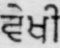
ਵੇਖੀ
